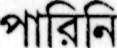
পারিনি
